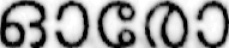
ഓരോ
